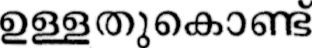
ഉള്ളതുകൊണ്ട്
